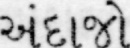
અંદાજો
